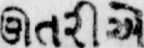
ઊતરીએ
